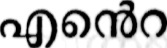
എന്റെ
